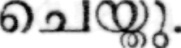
ചെയ്തു.
